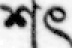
শৎ
